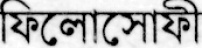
ফিলোসোফী
